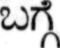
ಬಗ್ಗೆ
